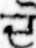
ਦੋ
